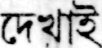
দেখাই
